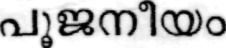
പൂജനീയം
